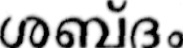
ശബ്ദം
